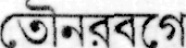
তৌনরবগে
